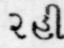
રહી
